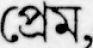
প্রেম,
